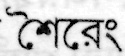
শৈরেং
